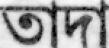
তাদা
